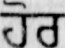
ਹੋਰ
